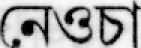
নেওচা
